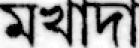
মখাদা
